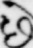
છે
